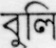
বুলি
